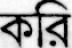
করি
